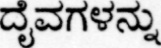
ದೈವಗಳನ್ನು
